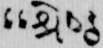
“શ્રેષ્ઠ
